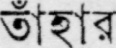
তাঁহার
